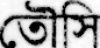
তৌসি
